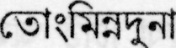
তোংমিন্নদুনা
